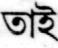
তাই
